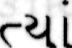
ત્યાં
